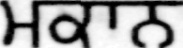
ਮਕਾਨ
